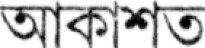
আকাশত
